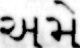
અમે
